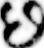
છ
